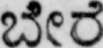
ಬೇರೆ
